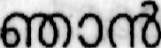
ഞാന്‍
